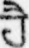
ਹੈ
